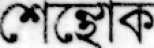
শেন্থোক
